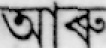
আৰু
